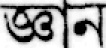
জ্ঞান
